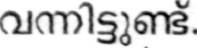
വന്നിട്ടുണ്ട്.
